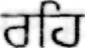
ਰਹਿ
